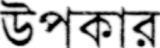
উপকার
